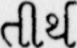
તીર્થ
